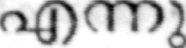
എന്നു
